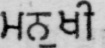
ਮਨੁਖੀ
